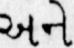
અને
